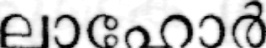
ലാഹോര്‍
